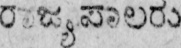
ರಾಜ್ಯಪಾಲರು
